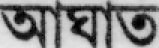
আঘাত
